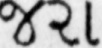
જરા
